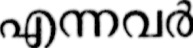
എന്നവര്‍
